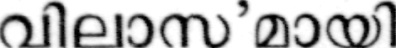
വിലാസ'മായി
